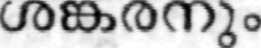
ശങ്കരനും
